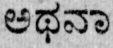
ಅಥವಾ
